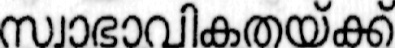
സ്വാഭാവികതയ്ക്ക്
